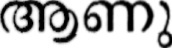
ആണു
